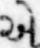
એ
